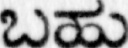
ಬಹು
